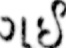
ગઈ
